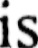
is
